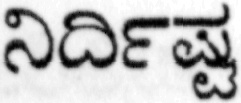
ನಿರ್ದಿಷ್ಟ
